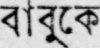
বাবুকে
